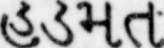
હડમત
